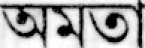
অমতা
